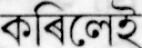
কৰিলেই
